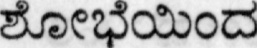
ಶೋಭೆಯಿಂದ
